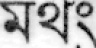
মথং
